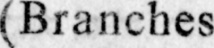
(Branches
